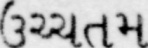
ઉચ્ચતમ
